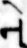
ને
